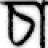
চা
